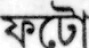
ফটো
